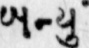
બન્યું
